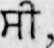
ਸੀ,
